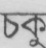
চকু
